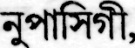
নুপাসিগী,
